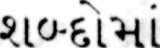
શબ્દોમાં
